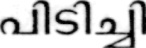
പിടിച്ചി
